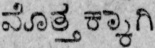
ಮೊತ್ತಕ್ಕಾಗಿ
